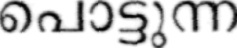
പൊട്ടുന്ന
